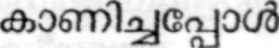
കാണിച്ചപ്പോള്‍
